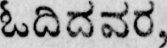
ಓದಿದವರ,
